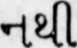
નથી
